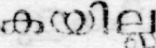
കയില്ല.
